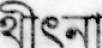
থীৎনা
